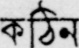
কঠিন
